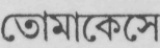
তোমাকেসে
